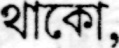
থাকো,
